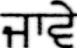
ਜਾਵੇ
